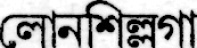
লোনশিল্লগা
